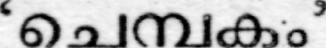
'ചെമ്പകം'
